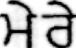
ਮੇਰੇ
